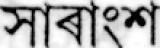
সাৰাংশ
